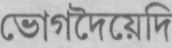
ভোগদৈয়েদি
